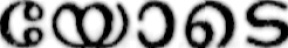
യോടെ
